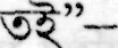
তই"-
